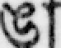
ঙা
